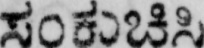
ಸಂಕುಚಿಸಿ
